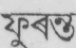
ফুৰন্ত
